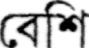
বেশি
